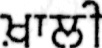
ਖ਼ਾਲੀ
